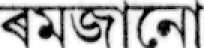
ৰমজানো
